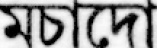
মচাদো
